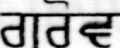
ਗਰੋਵ
